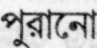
পুরানো
